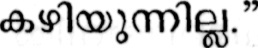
കഴിയുന്നില്ല.”
